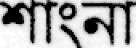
শাংনা
